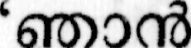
'ഞാന്‍
